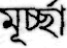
মূর্চ্ছা
